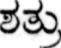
ಶತ್ರು
